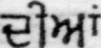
ਦੀਆਂ
